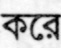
করে
